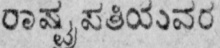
ರಾಷ್ಟ್ರಪತಿಯವರ
